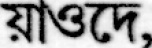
য়াওদে,
